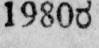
1980ರ
